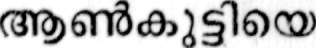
ആണ്‍കുട്ടിയെ
